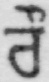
ਰੌ
